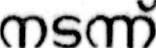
നടന്ന്
